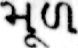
મૂળ
